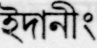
ইদানীং
